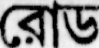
রোড
